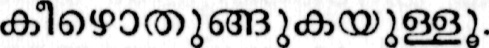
കീഴൊതുങ്ങുകയുള്ളൂ.
